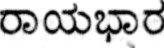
ರಾಯಭಾರ
